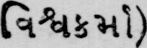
વિશ્વકર્મા)
